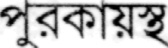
পুরকায়স্থ
